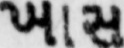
ખાસ
